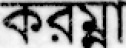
করম্না
